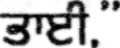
ਭਾਈ,''
